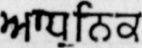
ਆਧੁਨਿਕ
